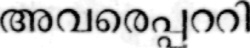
അവരെപ്പററി
